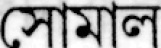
সোমাল
